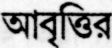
আবৃত্তির
